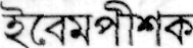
ইবেমপীশক
